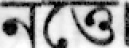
নত্তে।
